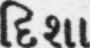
દિશા
